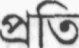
প্রতি
